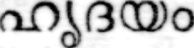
ഹൃദയം
